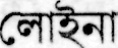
লোইনা
